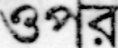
ওপর
